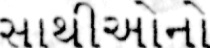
સાથીઓનો
